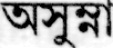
অসুম্না
